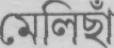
মেলিছাঁ
